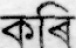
কৰি
